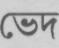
ভেদ
